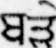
ਬੜੇ
